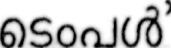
ടെംപള്‍'
